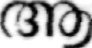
ആ
